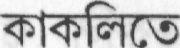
কাকলিতে
